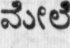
ಮೇಲೆ
